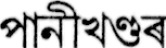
পানীখণ্ডৰ
